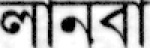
লানবা
